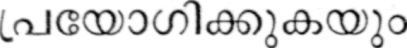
പ്രയോഗിക്കുകയും
